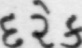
દરેક
